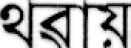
থৱায়
